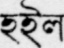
হইল
